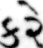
કરે
